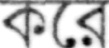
করে
